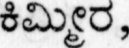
ಕಿಮ್ಮೀರ,
